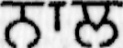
ਨਾਲ
